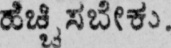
ಹೆಚ್ಚಿಸಬೇಕು.
